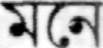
মনে
